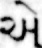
એ
